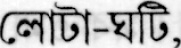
লোটা-ঘটি,
